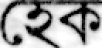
হেক
